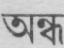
অন্ধ
